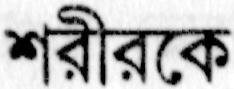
শরীরকে
